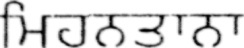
ਮਿਹਨਤਾਨਾ
